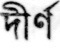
দীর্ণ
